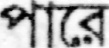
পারে
